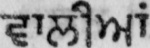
ਵਾਲੀਆਂ
